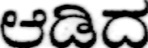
ಆಡಿದ
